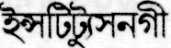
ইন্সটিট্যুসনগী
